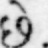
છે.
